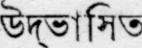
উদ্‌ভাসিত
